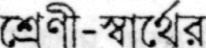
শ্রেণী-স্বার্থের
